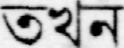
তখন
